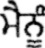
ਮੈਨੂੰ
